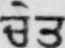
ਚੇਤ
